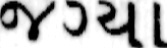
જગ્યા
